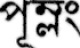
পূম্লং
